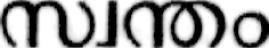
സ്വന്തം
